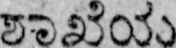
ಶಾಖೆಯ
